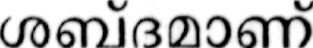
ശബ്ദമാണ്
